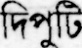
দিপুটি
